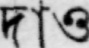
দাও
